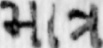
માત્ર
